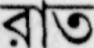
রাত
